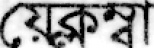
য়েক্লম্বা
